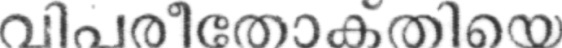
വിപരീതോക്തിയെ
